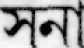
সনা
